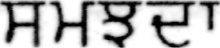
ਸਮਝਦਾ
